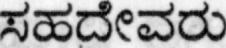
ಸಹದೇವರು
